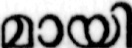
മായി
